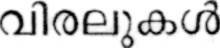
വിരലുകള്‍
